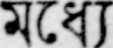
মধ্যে
